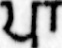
ਪਾ
